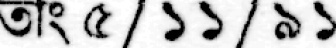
তাং৫/১১/৯১
